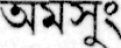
অমসুং
